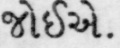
જોઈએ.
